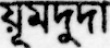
য়ূমদুদা
